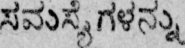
ಸಮಸ್ಯೆಗಳನ್ನು
